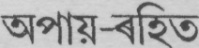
অপায়-ৰহিত
